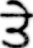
ਤੇ
